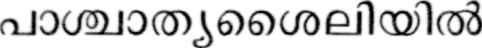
പാശ്ചാത്യശൈലിയില്‍
